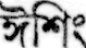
ঈশিং
